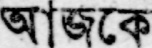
আজকে
